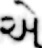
એ
